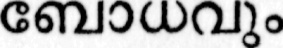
ബോധവും
